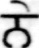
ਨੇ
